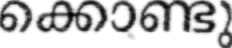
ക്കൊണ്ടു
